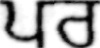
ਪਰ
